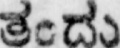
ತಂದು
